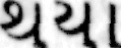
થયા
